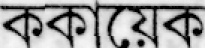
ককায়েক
